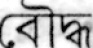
বৌদ্ধ
